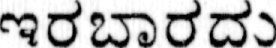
ಇರಬಾರದು
